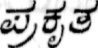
ಪ್ರಕೃತ
